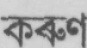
কৰুণ
